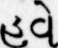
હવે
